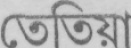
তেতিয়া
